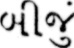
બીજું
